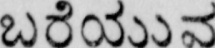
ಬರೆಯುವ
